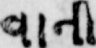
વાની
